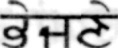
ਭੇਜਣੇ
